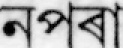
নপৰা
